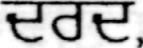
ਦਰਦ,
